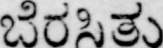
ಬೆರಸಿತು
